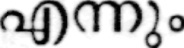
എന്നും
